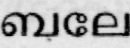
ബലേ
